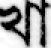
খা
